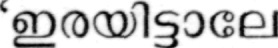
'ഇരയിട്ടാലേ
